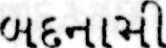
બદનામી
